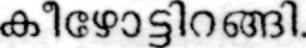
കീഴോട്ടിറങ്ങി.
